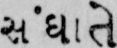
સંઘાતે
